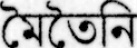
মৈতৈনি
